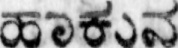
ಹಾಕುವ
